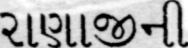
રાણાજીની
